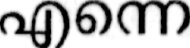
എന്നെ
